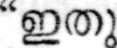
“ഇതു
